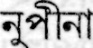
নুপীনা
